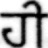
ਹੀ
